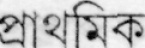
প্রাথমিক
